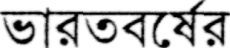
ভারতবর্ষের
